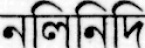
নলিনিদি
